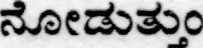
ನೋಡುತ್ತು೦
